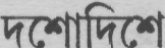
দশোদিশে
